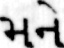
મને
